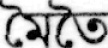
মৈতৈ
